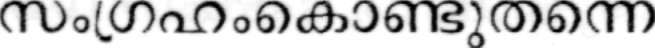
സംഗ്രഹംകൊണ്ടുതന്നെ
